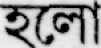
হলো
